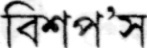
বিশপ'স
